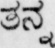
ತನ್ನ
